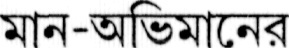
মান-অভিমানের
